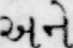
અને
